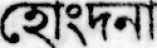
হোংদনা
